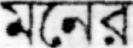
মনের
